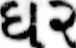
ઘર
